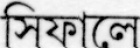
সিফালে
